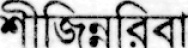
শীজিন্নরিবা
